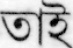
তাই
